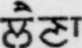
ਲੈਣਾ
